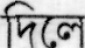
দিলে
